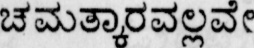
ಚಮತ್ಕಾರವಲ್ಲವೇ
